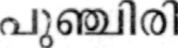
പുഞ്ചിരി
